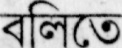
বলিতে
